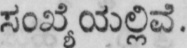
ಸಂಖ್ಯೆಯಲ್ಲಿವೆ.
